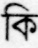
কি
